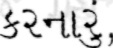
કરનારું,
